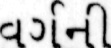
વર્ગની
